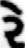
રે
